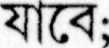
যাবে;
